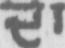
ਦਾ
